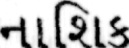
નાશિક
